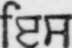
ਇਸ
